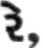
રે,
